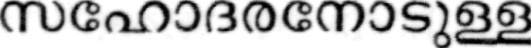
സഹോദരനോടുള്ള
